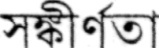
সঙ্কীর্ণতা
